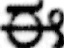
ಈ
